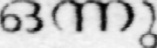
ഒന്നു
